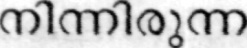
നിന്നിരുന്ന
